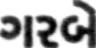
ગરબે
